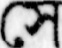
সে
